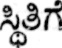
ಸ್ಥಿತಿಗೆ
